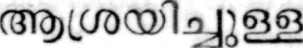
ആശ്രയിച്ചുള്ള
